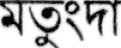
মতুংদা
